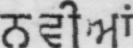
ਨਵੀਆਂ
